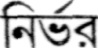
নির্ভর
